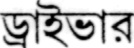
ড্রাইভার
